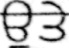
ਉਤੇ
